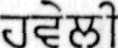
ਹਵੇਲੀ
